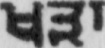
ਖੜਾ
